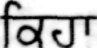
ਕਿਹਾ
